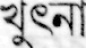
খুৎনা
